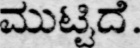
ಮುಟ್ಟಿದೆ.
